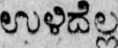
ಉಳಿದೆಲ್ಲ
